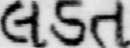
લડત
